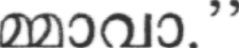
മ്മാവാ."
